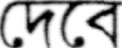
দেবে
